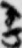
કે
